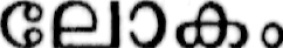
ലോകം
